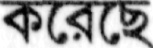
করেছে
